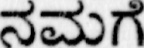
ನಮಗೆ
